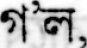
গ'ল,
